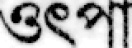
ওৎপা
